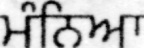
ਮੰਨਿਆ
